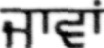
ਜਾਵਾਂ
